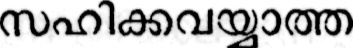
സഹിക്കവയ്യാത്ത
